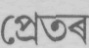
প্ৰেতৰ
